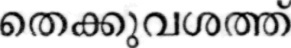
തെക്കുവശത്ത്
